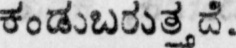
ಕಂಡುಬರುತ್ತದೆ.
